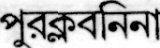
পুরক্লবনিনা
